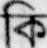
কি
